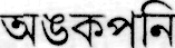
অঙকপনি
